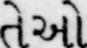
તેઓ
